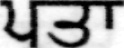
ਪਤਾ
